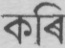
কৰি
